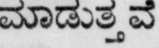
ಮಾಡುತ್ತವೆ
